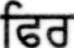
ਫਿਰ
